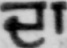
ਦਾ
